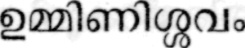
ഉമ്മിണിശ്ശവം
